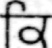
ਕਿ
